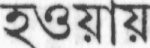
হওয়ায়
